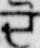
ਦੋ
